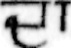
ਦਾ
